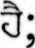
ਹੈ;
